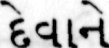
દેવાને
